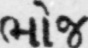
ભોજ
